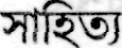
সাহিত্য
